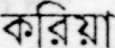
করিয়া
